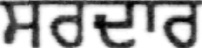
ਸਰਦਾਰ
